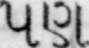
પણ
